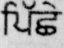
ਪਿੱਛੇ
